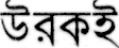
উরকই
